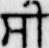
ਸੀ
